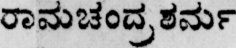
ರಾಮಚಂದ್ರಶರ್ಮ
